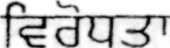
ਵਿਰੋਧਤਾ
